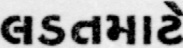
લડતમાટે
